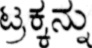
ಟ್ರಕ್ಕನ್ನು
